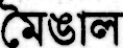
মৈঙাল
